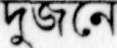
দুজনে
